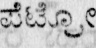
ಪೆಟ್ರೋ
